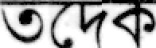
তদেক
